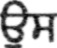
ਉਸ
